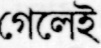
গেলেই
